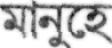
মানুহে
